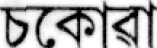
চকোৱা
